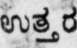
ಉತ್ತರ
